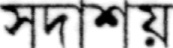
সদাশয়
